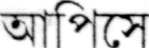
আপিসে
